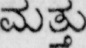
ಮತ್ತು
